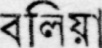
বলিয়া
